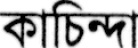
কাচিন্দা
